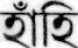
হাঁহি
